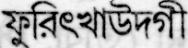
ফুরিৎখাউদগী
